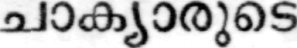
ചാക്യാരുടെ
